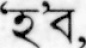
'হ'ব,
